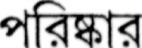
পরিষ্কার
